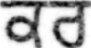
ਕਰ
